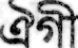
ঐগী
